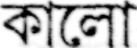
কালো
